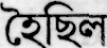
হৈছিল
